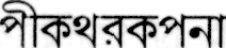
পীকথরকপনা
